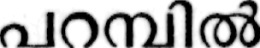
പറമ്പില്‍
